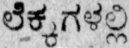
ಲೆಕ್ಕಗಳಲ್ಲಿ
